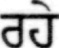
ਰਹੇ
